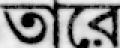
তারে
